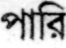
পারি
